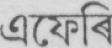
এফেৰি
